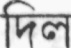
দিল
